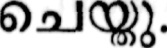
ചെയ്തു.
